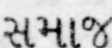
સમાજ
